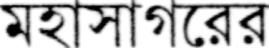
মহাসাগরের
